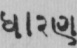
ધારણ
